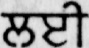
ਲਈ
